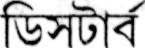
ডিসটার্ব
